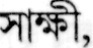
সাক্ষী,
